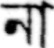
না
